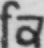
ਕਿ
